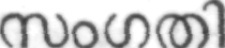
സംഗതി
